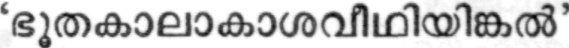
'ഭൂതകാലാകാശവീഥിയിങ്കല്‍'
